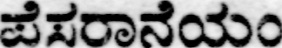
ಪೆಸರಾನೆಯ೦
